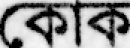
কোক
